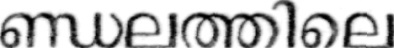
ണ്ഡലത്തിലെ
